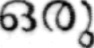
ഒരു
